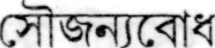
সৌজন্যবোধ
